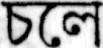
চলে
